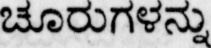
ಚೂರುಗಳನ್ನು
